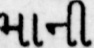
માની
